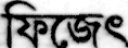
ফিজেৎ
